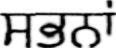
ਸਭਨਾਂ
